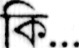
কি...
